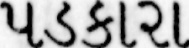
પડકારા
